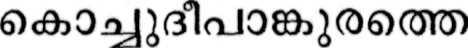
കൊച്ചുദീപാങ്കുരത്തെ
